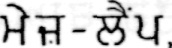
ਮੇਜ਼-ਲੈਂਪ,
